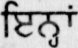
ਇਨ੍ਹਾਂ
